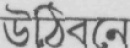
উঠিবনে
